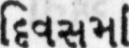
દિવસમાં
